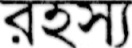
রহস্য
